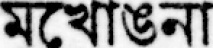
মখোঙনা
